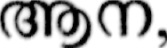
ആന,
